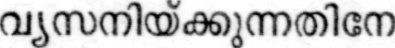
വ്യസനിയ്ക്കുന്നതിനേ
